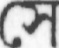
সে
